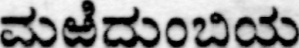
ಮಱಿದುಂಬಿಯ
